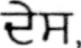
ਦੇਸ,
